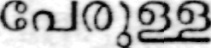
പേരുള്ള
